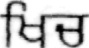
ਖਿਚ
